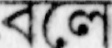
বলে
